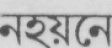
নহয়নে
